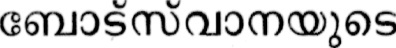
ബോട്സ്വാനയുടെ
